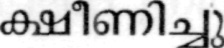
ക്ഷീണിച്ചു
